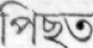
পিছত
